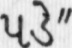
પડે"
